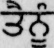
ਤੈਨੂੰ
